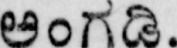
ಅಂಗಡಿ.
